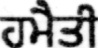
ਹਮੈਤੀ
